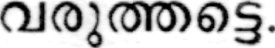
വരുത്തട്ടെ.
